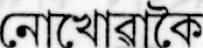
নোখোৱাকৈ
